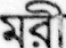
মরী
